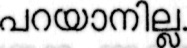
പറയാനില്ല.
